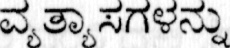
ವ್ಯತ್ಯಾಸಗಳನ್ನು
